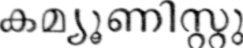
കമ്യൂണിസ്റ്റു
